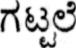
ಗಟ್ಟಲೆ
